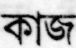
কাজ
